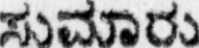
ಸುಮಾರು
